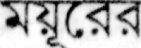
ময়ূরের
